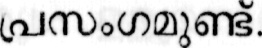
പ്രസംഗമുണ്ട്.
